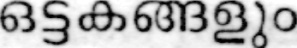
ഒട്ടകങ്ങളും
